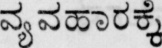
ವ್ಯವಹಾರಕ್ಕೆ
